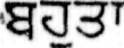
ਬਹੁਤਾ
